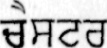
ਚੈਸਟਰ
